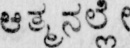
ಆತ್ಮನಲ್ಲೇ
